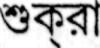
শুক্রা
